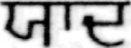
ਯਾਦ
